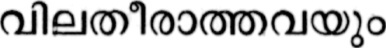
വിലതീരാത്തവയും
